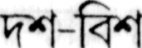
দশ-বিশ
